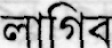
লাগিব
